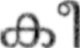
കീ
